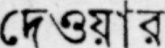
দেওয়ার
